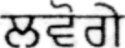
ਲਵੋਗੇ
